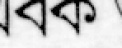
থবক
